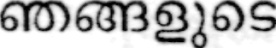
ഞങ്ങളുടെ
